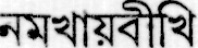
নমখায়বীখি
